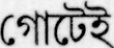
গোটেই
